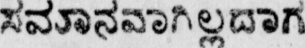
ಸಮಾನವಾಗಿಲ್ಲದಾಗ
